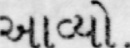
આવ્યો.
